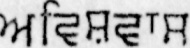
ਅਵਿਸ਼ਵਾਸ
